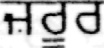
ਜ਼ਰੂਰ
